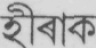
হীৰাক
